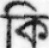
কি
